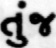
તુંજ
